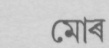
মোৰ
